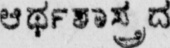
ಆರ್ಥಶಾಸ್ತ್ರದ
